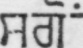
ਸਗੋਂ
